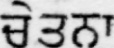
ਚੇਤਨਾ
